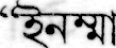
“ইনম্মা
